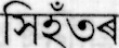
সিহঁতৰ
